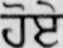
ਹੋਏ
